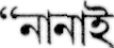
"নানাই
